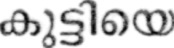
കുട്ടിയെ
